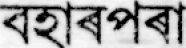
বহাৰপৰা
